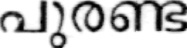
പുരണ്ട
